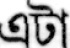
এটা
